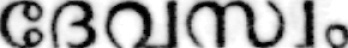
ദേവസ്വം
